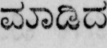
ಮಾಡಿದ
